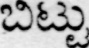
ಬಿಟ್ಟು
